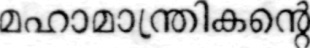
മഹാമാന്ത്രികന്റെ
